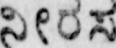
ನೀರಸ
